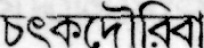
চৎকদৌরিবা
